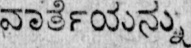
ವಾರ್ತೆಯನ್ನು
